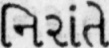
નિરાંતે
